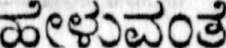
ಹೇಳುವಂತೆ
